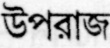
উপরাজ
